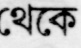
থেকে
